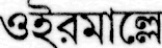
ওইরমাল্লে
